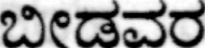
ಬೀಡವರ
